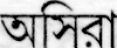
অসিরা
